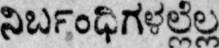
ನಿರ್ಬಂಧಿಗಳಲ್ಲೆಲ್ಲ
